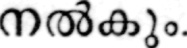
നല്‍കും.
